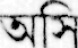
অসি
